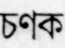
চণক
